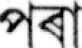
পৰা
